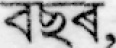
বছৰ,
